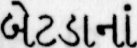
બેટડાનાં
